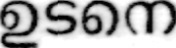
ഉടനെ
